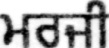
ਮਰਜੀ
